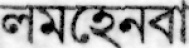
লমহেনবা
